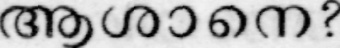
ആശാനെ?
